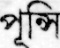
পূন্সি
